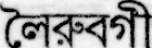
লৈরুবগী
